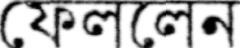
ফেললেন
